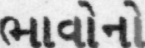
ભાવોનો
